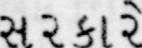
સરકારે
